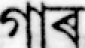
গাৰ
